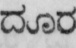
ದೂರ
